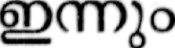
ഇന്നും
